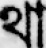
থা
